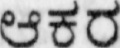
ಆಕರ
